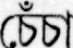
চেঁচা
